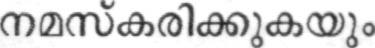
നമസ്കരിക്കുകയും
